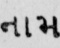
નામ
